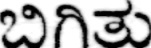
ಬಿಗಿತು
